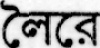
লৈরে
